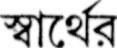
স্বার্থের
